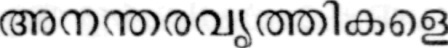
അനന്തരവൃത്തികളെ
